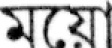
ময়ো
